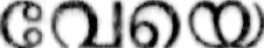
വേയെ
